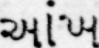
આંખ
